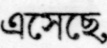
এসেছে,
